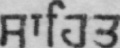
ਸਾਹਿਤ
